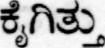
ಕೈಗಿತ್ತು
